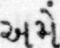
અમે
